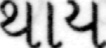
થાય
